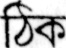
ঠিক
